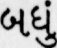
બધું
